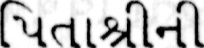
પિતાશ્રીની
